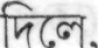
দিলে,
